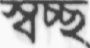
স্বচ্ছ
